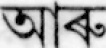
আৰু
